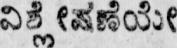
ವಿಶ್ಲೇಷಣೆಯೇ
